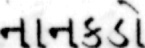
નાનકડો
